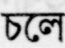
চলে
